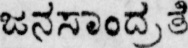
ಜನಸಾಂದ್ರತೆ
